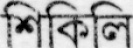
শিকিলি
